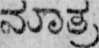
ಮಾತ್ರ
